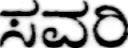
ಸವರಿ
